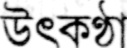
উৎকণ্ঠা
